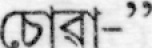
চোৱা-"
